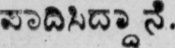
ಪಾದಿಸಿದ್ದಾನೆ.
